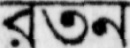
রতন
